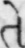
તે
